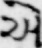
એ
